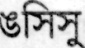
ঙসিসু
